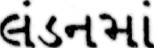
લંડનમાં
